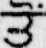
ਤੋਂ
